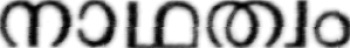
നാഥത്വം
